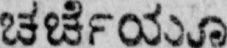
ಚರ್ಚೆಯೂ
